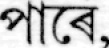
পাৰে,
